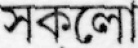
সকলো
